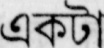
একটা
